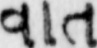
વાત
